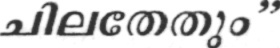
ചിലതേതും"
